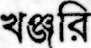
খঞ্জরি
